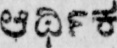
ಆರ್ಥಿಕ
